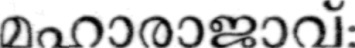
മഹാരാജാവ്:
